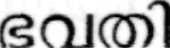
ഭവതി
